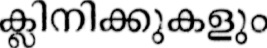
ക്ലിനിക്കുകളും
